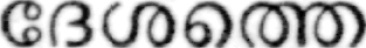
ദേശത്തെ
